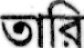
তারি
